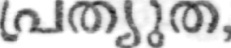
പ്രത്യുത,
